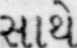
સાથે
